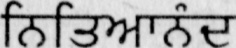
ਨਿਤਿਆਨੰਦ
